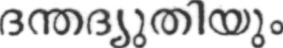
ദന്തദ്യുതിയും
